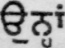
ਉਨ੍ਹਾਂ
